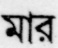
মার
